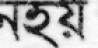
নহয়
